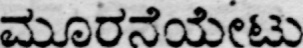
ಮೂರನೆಯೇಟು
